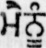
ਮੈਨੂੰ
